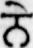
ਨੇ
